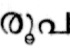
രൂപ
